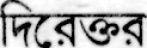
দিরেক্তর
